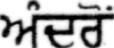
ਅੰਦਰੋਂ
